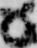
ರ
